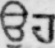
ਉਹ
